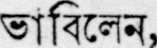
ভাবিলেন,
